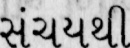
સંચયથી
